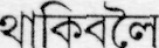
থাকিবলৈ
